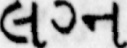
લગ્ન
